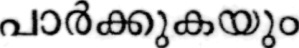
പാര്‍ക്കുകയും
